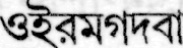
ওইরমগদবা
